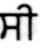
ਸੀ
